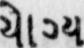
યોગ્ય
